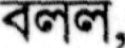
বলল,
